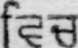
ਵਿਚ
